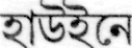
হাউইনে
